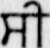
ਸੀ
